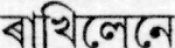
ৰাখিলেনে
